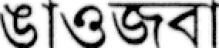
ঙাওজবা
